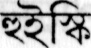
হুইস্কি
